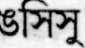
ঙসিসু
